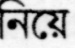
নিয়ে
